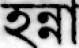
হন্না
